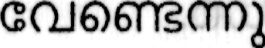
വേണ്ടെന്നു
